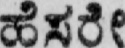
ಹೆಸರೇ
